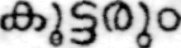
കൂട്ടരും
